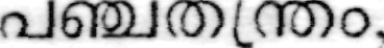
പഞ്ചതന്ത്രം,
